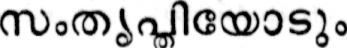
സംതൃപ്തിയോടും
